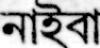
নাইবা
